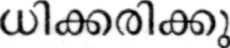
ധിക്കരിക്കു
